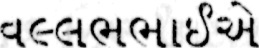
વલ્લભભાઈએ
